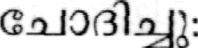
ചോദിച്ചു:
